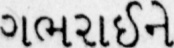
ગભરાઈને
